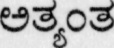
ಅತ್ಯಂತ
